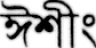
ঈশীং
